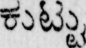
ಕುಟ್ಟು
